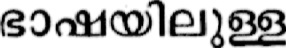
ഭാഷയിലുള്ള
